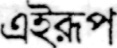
এইরূপ
